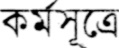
কর্মসূত্রে
